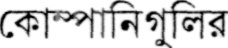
কোম্পানিগুলির
